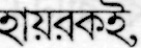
হায়রকই,
